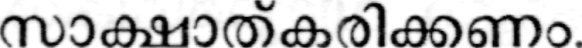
സാക്ഷാത്കരിക്കണം.
